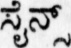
ಸೈನ್ಸ್
